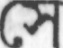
সে
